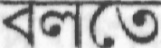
বলতে
